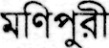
মণিপুরী
